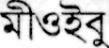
মীওইবু
